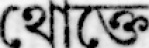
থোক্তে
